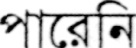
পারেনি
